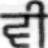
ਵੀ
